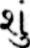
શું
